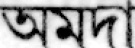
অমদা
